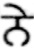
ਨੇ
